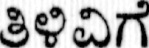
ತಿಳಿವಿಗೆ
